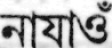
নাযাওঁ
